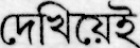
দেখিয়েই
